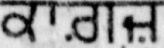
ਕਾਗ਼ਜ਼
